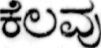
ಕೆಲವು
